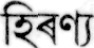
হিৰণ্য
